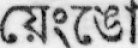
য়েংঙো
